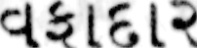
વફાદાર
